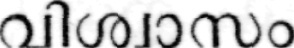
വിശ്വാസം
